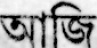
আজি
